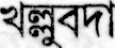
খল্লুবদা
